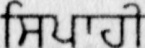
ਸਿਪਾਹੀ
